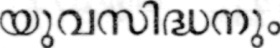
യുവസിദ്ധനും
